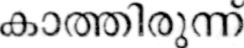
കാത്തിരുന്ന്
